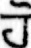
ਹੋ
